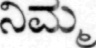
ನಿಮ್ಮ
